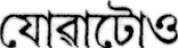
যোৱাটোও
